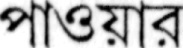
পাওয়ার
